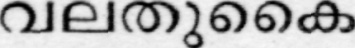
വലതുകൈ
